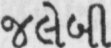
જલેબી
